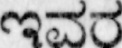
ಇವರ
